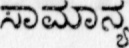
ಸಾಮಾನ್ಯ
